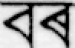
বৰ
